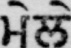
ਮੇਲੇ
